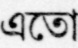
এতো
